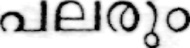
പലരും
